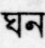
ঘন
